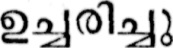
ഉച്ചരിച്ചു
